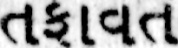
તફાવત
